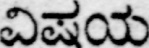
ವಿಷಯ
